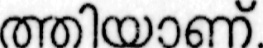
ത്തിയാണ്.
